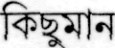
কিছুমান
